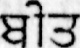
ਬੀਤ
